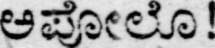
ಅಪೋಲೊ!
